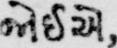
જોઈએ,
